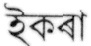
ইকৰা
